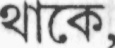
থাকে,
